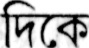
দিকে
